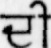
ਦੀ
